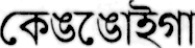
কেঙঙোইগা
